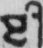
ਈ
